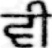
ਵੀ
